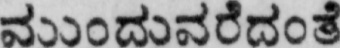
ಮುಂದುವರೆದಂತೆ
